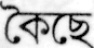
কৈছে
